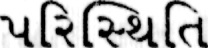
પરિસ્થિતિ
